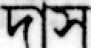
দাস
